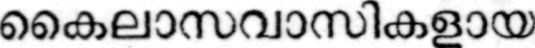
കൈലാസവാസികളായ
